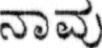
ನಾವು
